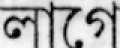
লাগে
